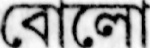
বোলো
